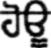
ਹੋਊ
